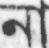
না
